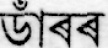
ডাঁৰৰ
